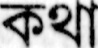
কথা
